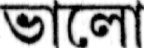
ভালো
